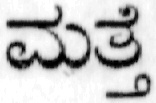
ಮತ್ತೆ
